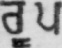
ਰੂਪ
